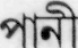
পানী
